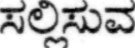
ಸಲ್ಲಿಸುವ
